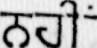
ਨਹੀਂ
